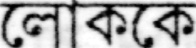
লোককে
